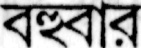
বহুবার
